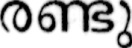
രണ്ടു
